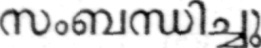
സംബന്ധിച്ചു
